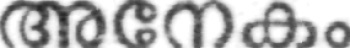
അനേകം
